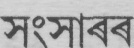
সংসাৰৰ
